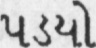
પડયો
